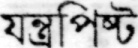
যন্ত্রপিষ্ট
